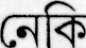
নেকি
